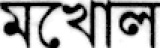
মখোল
